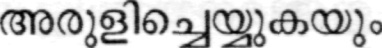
അരുളിച്ചെയ്യുകയും
